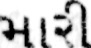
મારી
